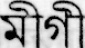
মীগী
